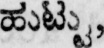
ಹುಟ್ಟು,
